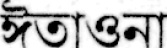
ঈতাওনা
